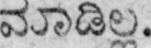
ಮಾಡಿಲ್ಲ.
